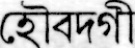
হৌবদগী
